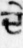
ਦੇ
